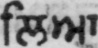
ਲਿਆ
